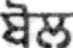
ਬੋਲ
